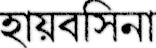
হায়বসিনা
